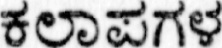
ಕಲಾಪಗಳ
